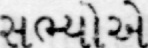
સભ્યોએ
